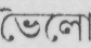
ভৈলো
